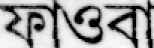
ফাওবা
